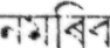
নমৰিব
